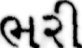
ભરી
